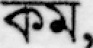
কম,
